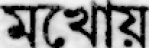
মখোয়
